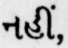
નહીં,
